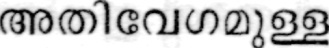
അതിവേഗമുള്ള
